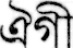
ঐগী
